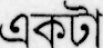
একটা
